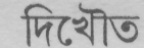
দিখৌত
